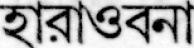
হারাওবনা
